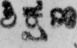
ಶಿಕ್ಷಣ
